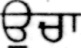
ਉਚਾ
